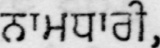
ਨਾਮਧਾਰੀ,
